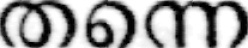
തന്നെ
